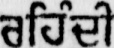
ਰਹਿੰਦੀ
